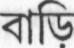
বাড়ি
